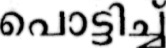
പൊട്ടിച്ച്
